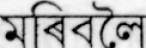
মৰিবলৈ
